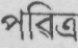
পৱিত্র
